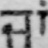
ਜਾਂ
